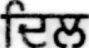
ਦਿਲ
